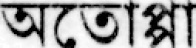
অতোপ্পা
